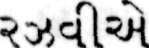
રઝવીએ
